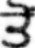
ਤੋਂ
